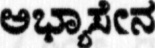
ಅಭ್ಯಾಸೇನ
